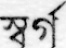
স্বর্গ
